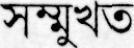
সন্মুখত
